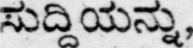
ಸುದ್ದಿಯನ್ನು,
